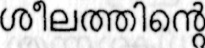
ശീലത്തിന്റെ
